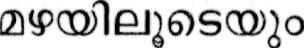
മഴയിലൂടെയും
